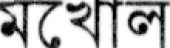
মখোল
